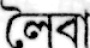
লৈবা
